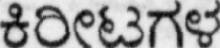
ಕಿರೀಟಗಳ
